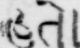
હતો
